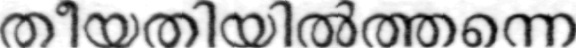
തീയതിയില്‍ത്തന്നെ
